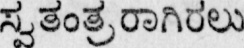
ಸ್ವತಂತ್ರರಾಗಿರಲು
